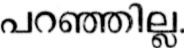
പറഞ്ഞില്ല.
